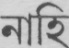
নাহি
